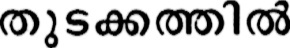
തുടക്കത്തില്‍
